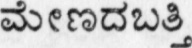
ಮೇಣದಬತ್ತಿ
